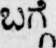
ಬಗ್ಗೆ
